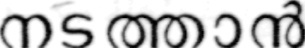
നടത്താന്‍
